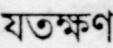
যতক্ষণ
